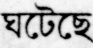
ঘটেছে
